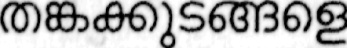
തങ്കക്കുടങ്ങളെ
